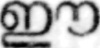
ഈ
